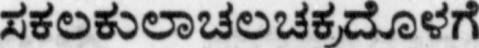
ಸಕಲಕುಲಾಚಲಚಕ್ರದೊಳಗೆ
